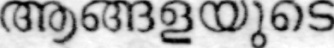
ആങ്ങളയുടെ
